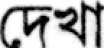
দেখা
